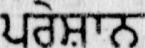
ਪਰੇਸ਼ਾਨ
